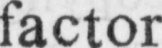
factor
